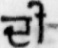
ਦੀ
